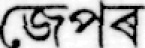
জেপৰ
